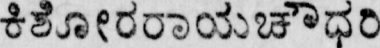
ಕಿಶೋರರಾಯಚೌಧರಿ
